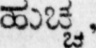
ಹುಚ್ಚ,
